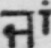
ਜਾਂ
